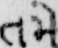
તમે
